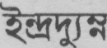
ইন্দ্ৰদ্যুম্ন
